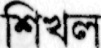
শিখল
